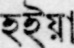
হইয়া
